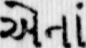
એનાં
